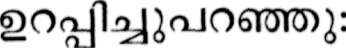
ഉറപ്പിച്ചുപറഞ്ഞു:
